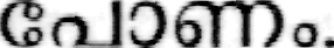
പോണം.
